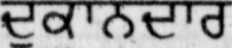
ਦੁਕਾਨਦਾਰ
